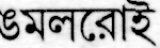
ঙমলরোই
